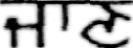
ਜਾਣ
